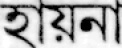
হায়না
